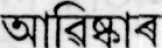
আৱিষ্কাৰ
